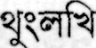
থুংলখি
